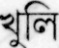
খুলি
